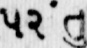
પરંતુ
